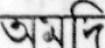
অমদি
